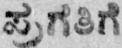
ಪ್ರಗತಿಗೆ
